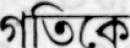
গতিকে
